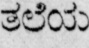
ತಲೆಯ
